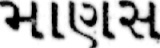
માણસ
